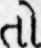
તો
